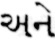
અને
